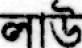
লাউ
